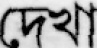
দেখা
